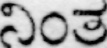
ನಿಂತ
